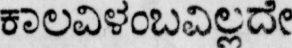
ಕಾಲವಿಳಂಬವಿಲ್ಲದೇ
